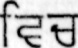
ਵਿਚ
